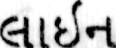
લાઇન
